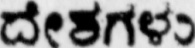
ದೇಶಗಳು
